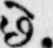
છે.
